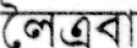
লৈত্রবা
